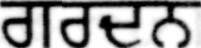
ਗਰਦਨ
